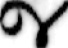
જ
